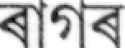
ৰাগৰ
